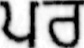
ਪਰ
